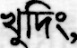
খুদিং,
